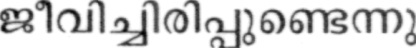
ജീവിച്ചിരിപ്പുണ്ടെന്നു
